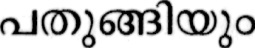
പതുങ്ങിയും
